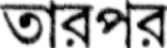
তারপর
